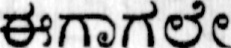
ಈಗಾಗಲೇ
